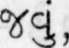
જવું,
